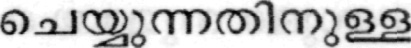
ചെയ്യുന്നതിനുള്ള
